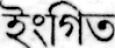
ইংগিত
